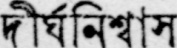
দীর্ঘনিশ্বাস
